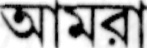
আমরা
